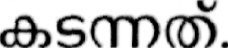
കടന്നത്.
